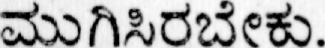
ಮುಗಿಸಿರಬೇಕು.
